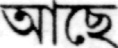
আছে
